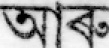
আৰু
